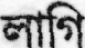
লাগি
